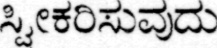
ಸ್ವೀಕರಿಸುವುದು
